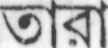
তারা
